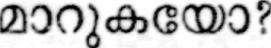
മാറുകയോ?
